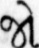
જો
